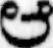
ಆ
